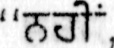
''ਨਹੀਂ,
